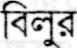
বিলুর
